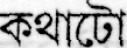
কথাটো
